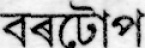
বৰটোপ
